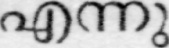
എന്നു
